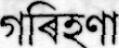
গৰিহণা
